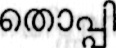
തൊപ്പി
